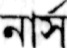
নার্স
